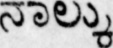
ನಾಲ್ಕು
